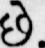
છે.
